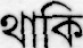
থাকি
